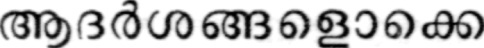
ആദര്‍ശങ്ങളൊക്കെ
